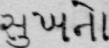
સુખનો
